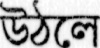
উঠলে
